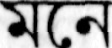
মনে
